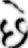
છે
